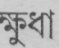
ক্ষুধা
